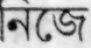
নিজে
